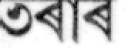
তৰাৰ
